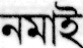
নমাই
